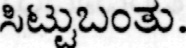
ಸಿಟ್ಟುಬಂತು.
